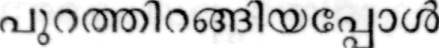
പുറത്തിറങ്ങിയപ്പോള്‍
